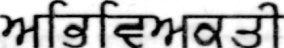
ਅਭਿਵਿਅਕਤੀ
